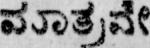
ಮಾತ್ರವೇ
